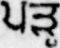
ਪੜ੍ਹ
